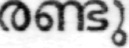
രണ്ടു
